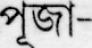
পূজা-
